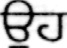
ਉਹ
